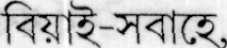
বিয়াই-সবাহে,
